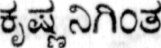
ಕೃಷ್ಣನಿಗಿಂತ
